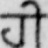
ਹੀ
